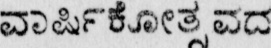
ವಾರ್ಷಿಕೋತ್ಸವದ
